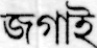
জগাই
